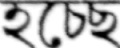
হচ্ছে
